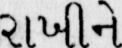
રાખીને
